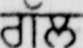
ਗੱਲ
